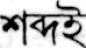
শব্দই
